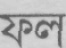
ফল
